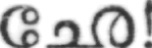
ഛേ!
